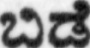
ಬಿಡೆ
